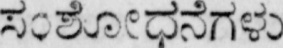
ಸಂಶೋಧನೆಗಳು
